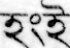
হংই
